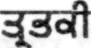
ਤ੍ਰਭਕੀ
